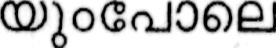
യുംപോലെ
